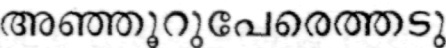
അഞ്ഞൂറുപേരെത്തടു
